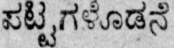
ಪಟ್ಟಿಗಳೊಡನೆ
